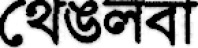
থেঙলবা
